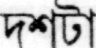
দশটা
